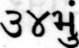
34મું
